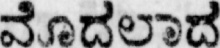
ಮೊದಲಾದ
